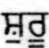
ਸ਼ੁਰੂ
